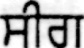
ਸੀਗ
